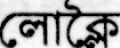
লোক্লৈ
